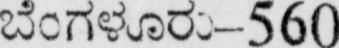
ಬೆಂಗಳೂರು-560
